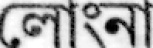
লোংনা
